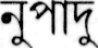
নুপাদু
